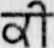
ਕੀ
